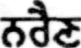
ਨਰੈਣ
